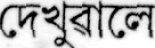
দেখুৱালে
